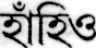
হাঁহিও
